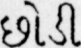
છોડી
